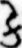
કે
